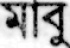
মাবু
